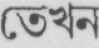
তেখন
